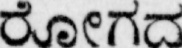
ರೋಗದ
